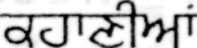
ਕਹਾਣੀਆਂ
